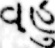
વહુ
